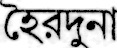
হৈরদুনা
